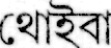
থোইবা
